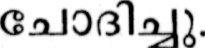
ചോദിച്ചു.
